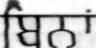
ਬਿਨਾਂ
